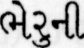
ભેરુની
